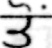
ਤੋਂ
